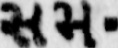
સમ-
